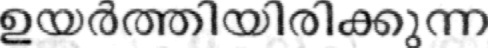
ഉയര്‍ത്തിയിരിക്കുന്ന
